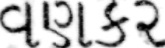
વણકર
